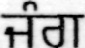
ਜੰਗ
